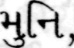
મુનિ,
